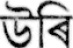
উৰি
